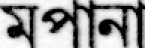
মপানা
